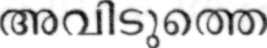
അവിടുത്തെ
